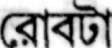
রোবটা
